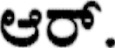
ಆರ್.
